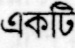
একটি
